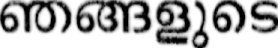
ഞങ്ങളുടെ
